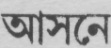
আসনে
